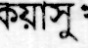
কয়াসু
